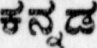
ಕನ್ನಡ
